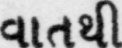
વાતથી
